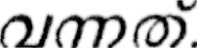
വന്നത്.
